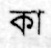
কা
